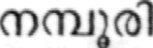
നമ്പൂരി
